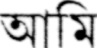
আমি
